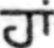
ਹਾਂ
